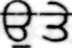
ਉਤੇ
